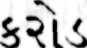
કરોડ
